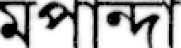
মপান্দা
